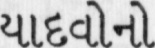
યાદવોનો
